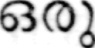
ഒരു
